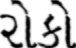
રોકો
